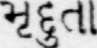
મૃદુતા
